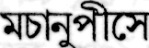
মচানুপীসে
